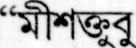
“মীশক্তুবু
